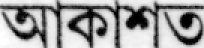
আকাশত
